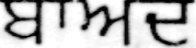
ਬਾਅਦ
